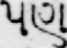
પણ
